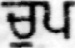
ਚੁਪ
